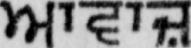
ਆਵਾਜ਼
